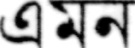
এমন
